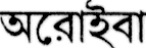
অরোইবা
